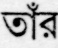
তাঁর
